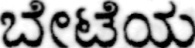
ಬೇಟೆಯ
